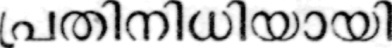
പ്രതിനിധിയായി
